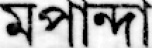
মপান্দা
